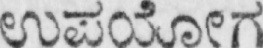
ಉಪಯೋಗ
